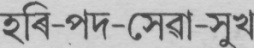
হৰি-পদ-সেৱা-সুখ
